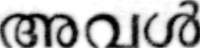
അവള്‍
